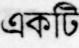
একটি
